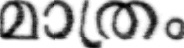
മാത്രം
